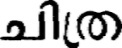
ചിത്ര
